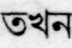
তখন
